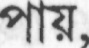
পায়,
